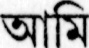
আমি
